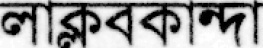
লাক্লবকান্দা
